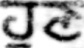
ਹੁਣ
